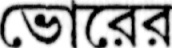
ভোরের
